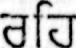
ਰਹਿ
